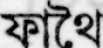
ফাথৈ
